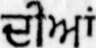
ਦੀਆਂ
